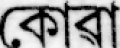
কোৱা
